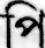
পি
